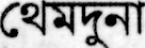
থেমদুনা
